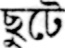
ছুটে
